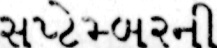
સપ્ટેમ્બરની
